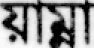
য়াম্না
